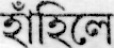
হাঁহিলে
